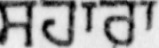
ਸਹਾਰਾ
